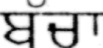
ਬੱਚਾ
